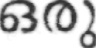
ഒരു
